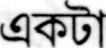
একটা
